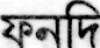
ফনদি
